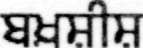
ਬਖ਼ਸ਼ੀਸ਼
